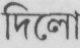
দিলো
